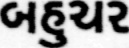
બહુચર
